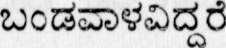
ಬಂಡವಾಳವಿದ್ದರೆ
